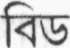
বিড
